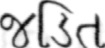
જડિત
